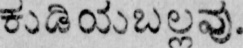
ಕುಡಿಯಬಲ್ಲವು.
